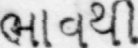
ભાવથી
